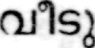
വീടു
